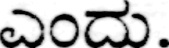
ಎಂದು.
